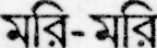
মরি-মরি
